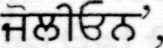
ਜੋਲੀਓਨ',
